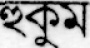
হুকুম
